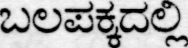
ಬಲಪಕ್ಕದಲ್ಲಿ
